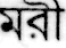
মরী
